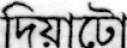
দিয়াটো
